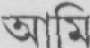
আমি
